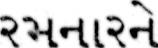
રમનારને
